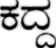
ಕದ್ದ
